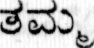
ತಮ್ಮ
